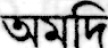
অমদি
